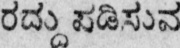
ರದ್ದುಪಡಿಸುವ
